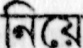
নিয়ে
